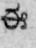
ಈ
